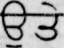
ਉਤੇ
